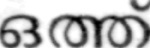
ഒത്ത്
